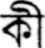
কী
